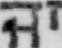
ਜਾ
